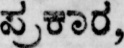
ಪ್ರಕಾರ,
